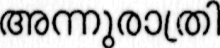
അന്നുരാത്രി
